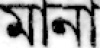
মানা
